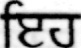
ਇਹ
